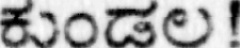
ಕುಂಡಲ!
